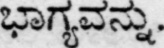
ಭಾಗ್ಯವನ್ನು.
